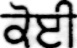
ਕੋਈ
